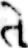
તે
